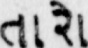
તારો
